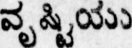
ವೃಷ್ಟಿಯು
